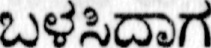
ಬಳಸಿದಾಗ
